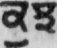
ਕੁਝ
